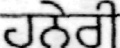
ਹਨੇਰੀ
